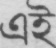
এই
